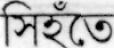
সিহঁতে
